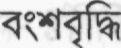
বংশবৃদ্ধি
